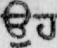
ਉਹ
